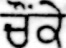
ਚੌਂਕੇ
